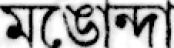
মঙোন্দা
